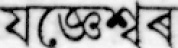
যজ্ঞেশ্বৰ
